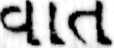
વાત
